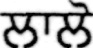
ਲਾਲੋ
